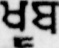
ਖੂਬ
